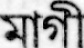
মাগী
